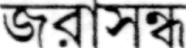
জরাসন্ধ
